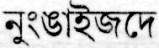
নুংঙাইজদে
